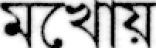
মখোয়
